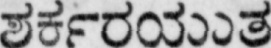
ಶರ್ಕರಯುತ
